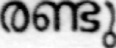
രണ്ടു
